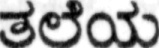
ತಲೆಯ
